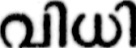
വിധി
